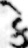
કે
